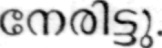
നേരിട്ടു.
